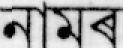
নামৰ
